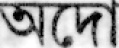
অদো
